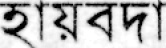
হায়বদা
